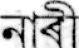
নাৰী
